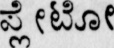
ಪ್ಲೇಟೋ
